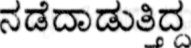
ನಡೆದಾಡುತ್ತಿದ್ದ
